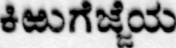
ಕಿಱುಗೆಜ್ಜೆಯ
